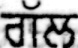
ਗੱਲ
